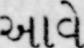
આવે
